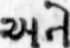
અને
